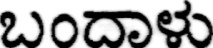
ಬಂದಾಳು
